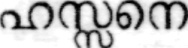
ഹസ്സനെ
